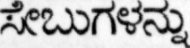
ಸೇಬುಗಳನ್ನು
